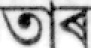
তাৰ
